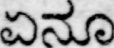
ಏನೂ
